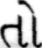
તો
